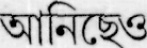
আনিছেও
